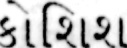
કોશિશ
